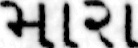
મારા
